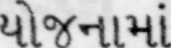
યોજનામાં
